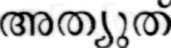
അത്യുത്
